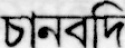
চানবদি
